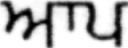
ਆਪ
